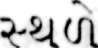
સ્થળે
